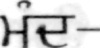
ਮੰਦ-
